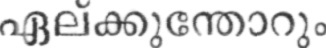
ഏല്ക്കുന്തോറും
